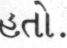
હતો.
